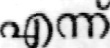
എന്ന്
